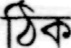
ঠিক
